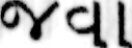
જવા
